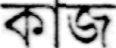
কাজ
